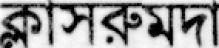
ক্লাসরুমদা
